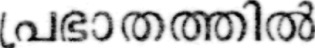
പ്രഭാതത്തില്‍
